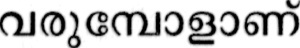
വരുമ്പോളാണ്
